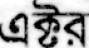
এক্টর
